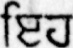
ਇਹ
